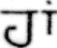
ਹਾਂ
